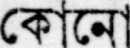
কোনো
